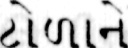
ટોળાને
